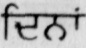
ਦਿਨਾਂ
